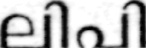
ലിപി
